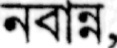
নবান্ন,
